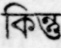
কিন্তু
